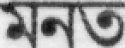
মনত
